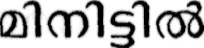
മിനിട്ടില്‍
